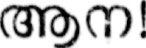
ആന!
